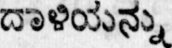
ದಾಳಿಯನ್ನು
